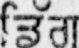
ਡਿੱਗ
